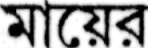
মায়ের
